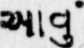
આવું
